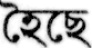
হৈছে
